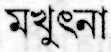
মখুৎনা
